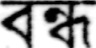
বন্ধ
